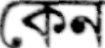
কেন
